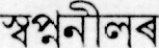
স্বপ্ননীলৰ
